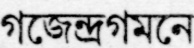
গজেন্দ্রগমনে
